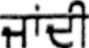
ਜਾਂਦੀ
